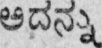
ಅದನ್ನು
